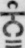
ਨੂੰ
